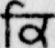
ਕਿ
